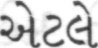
એટલે
